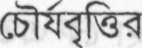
চৌর্যবৃত্তির
